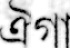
ঐগা
